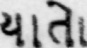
યાતો
